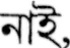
নাই,
